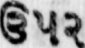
ઉપર
